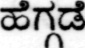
ಹೆಗ್ಗಡೆ
